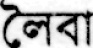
লৈবা
